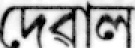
দেৱাল
